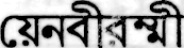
য়েনবীরম্মী
